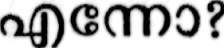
എന്നോ?
